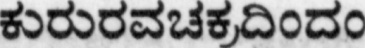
ಕುರುರವಚಕ್ರದಿಂದಂ
